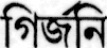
গিৰ্জনি
